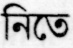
নিতে
